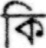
কি
